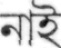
নাই
